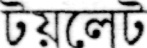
টয়লেট
